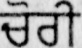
ਚੋਰੀ
